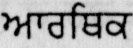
ਆਰਥਿਕ
